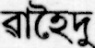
ৱাহৈদু
